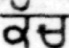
ਕੱਚ
